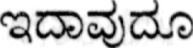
ಇದಾವುದೂ
